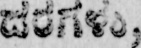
ದರಗಳು,
